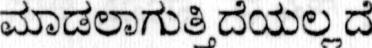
ಮಾಡಲಾಗುತ್ತಿದೆಯಲ್ಲದೆ
